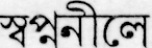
স্বপ্ননীলে
